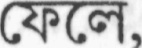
ফেলে,
